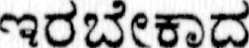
ಇರಬೇಕಾದ
